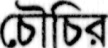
চৌচির
